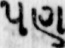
પણ
